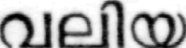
വലിയ
